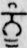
ਨੂੰ
